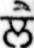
ਲੈ
